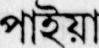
পাইয়া
